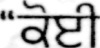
''ਕੋਈ
